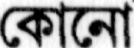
কোনো
